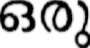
ഒരു
